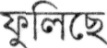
ফুলিছে
